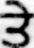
ਤੇ
